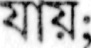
যায়;
